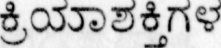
ಕ್ರಿಯಾಶಕ್ತಿಗಳ
